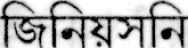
জিনিয়সনি
